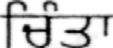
ਚਿੰਤਾ
